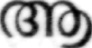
ആ
